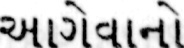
આગેવાનો
